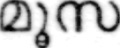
മൂസ
